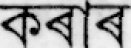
কৰাৰ
